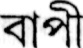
বাপী
